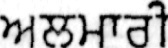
ਅਲਮਾਰੀ
